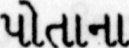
પોતાના
